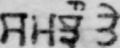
ਸਮਝੌਤੇ
